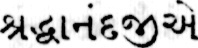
શ્રદ્ધાનંદજીએ
